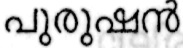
പുരുഷന്‍
